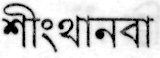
শীংথানবা
